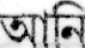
আনি
